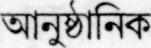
আনুষ্ঠানিক
